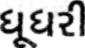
ધૂધરી
